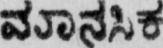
ಮಾನಸಿಕ
